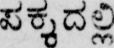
ಪಕ್ಕದಲ್ಲಿ
